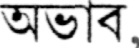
অভাব,
